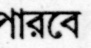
পারবে
